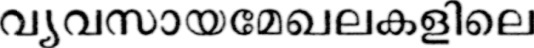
വ്യവസായമേഖലകളിലെ
